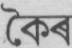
কৈৰ
